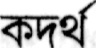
কদর্থ
